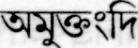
অমুক্তংদি
